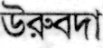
উরুবদা
